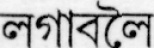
লগাবলৈ
